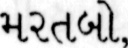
મરતબો,
